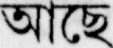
আছে
